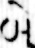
બે
